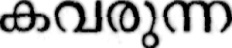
കവരുന്ന
